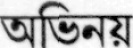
অভিনয়
